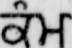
ਕੰਮ
